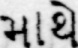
માથે
